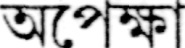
অপেক্ষা
